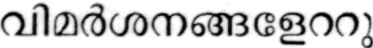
വിമര്‍ശനങ്ങളേററു
